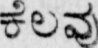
ಕೆಲವು
